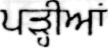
ਪੜ੍ਹੀਆਂ
